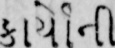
કાર્યોની
